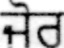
ਜੋਰ
